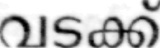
വടക്ക്
